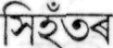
সিহঁতৰ
